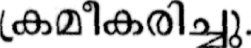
ക്രമീകരിച്ചു.
